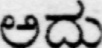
ಅದು
